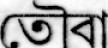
তৌবা
